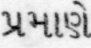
પ્રમાણે
